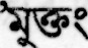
’মুক্তং
